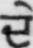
ਦੇ
